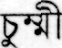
চুম্মী
